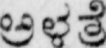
ಅಳತೆ
